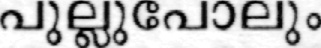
പുല്ലുപോലും
